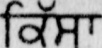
ਕਿੱਸਾ
